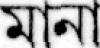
মানা
